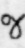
જ
